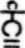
ਨੂੰ
